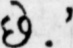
છે.'
